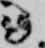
છે.
